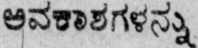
ಅವಕಾಶಗಳನ್ನು
